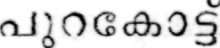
പുറകോട്ട്
